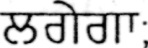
ਲਗੇਗਾ;
